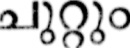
ചുറ്റും
